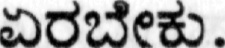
ಏರಬೇಕು.
